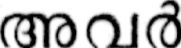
അവര്‍
